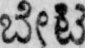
ಬೇಟಿ
